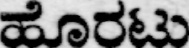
ಹೊರಟು
